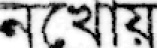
নখোয়
